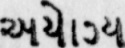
અયોગ્ય
